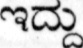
ಇದ್ದು
